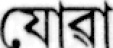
যোৱা
